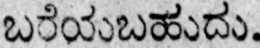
ಬರೆಯಬಹುದು.
